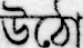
উঠো
